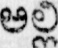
ಅಲ್ಲಿ
